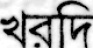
খরদি
